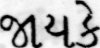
જાયકે
